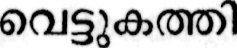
വെട്ടുകത്തി
